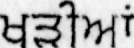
ਖੜੀਆਂ
